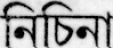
নিচিনা
